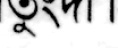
মতুংদা
